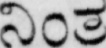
ನಿಂತ
